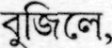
বুজিলে,
